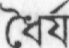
ধৈর্য
